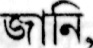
জানি,
